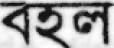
বহল
